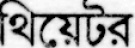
থিয়েটর
